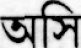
অসি
